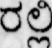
ರಲ್ಲಿ
